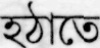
হঠাতে
